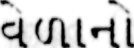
વેળાનો
